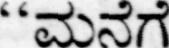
"ಮನೆಗೆ
